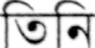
তিনি
